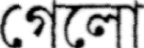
গেলো
